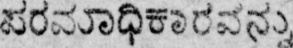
ಪರಮಾಧಿಕಾರವನ್ನು
